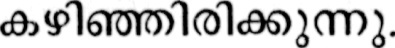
കഴിഞ്ഞിരിക്കുന്നു.
